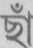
ছাঁ
